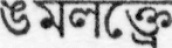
ঙমলক্ত্রে
